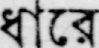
ধারে
